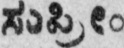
ಸುಪ್ರೀಂ
